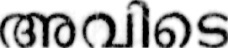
അവിടെ
